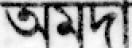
অমদা
